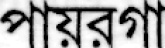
পায়রগা
